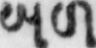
બળ
